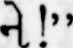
ને!"
